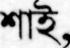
শাই,
